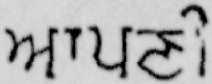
ਆਪਣੀ
